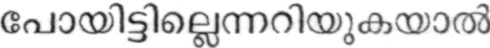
പോയിട്ടില്ലെന്നറിയുകയാല്‍
